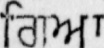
ਗਿਆ
